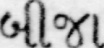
બીજા
